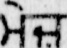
ਮੇਜ਼
